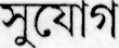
সুযোগ
